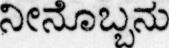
ನೀನೊಬ್ಬನು
